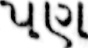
પણ
